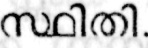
സ്ഥിതി.
